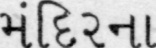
મંદિરના
